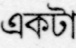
একটা
